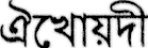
ঐখোয়দী
